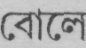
বোলে
